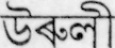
উৰুলী
